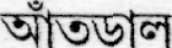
আঁতডাল
